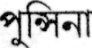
পুন্সিনা
